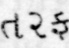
તરફ
